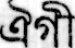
ঐগী
